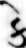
કે
